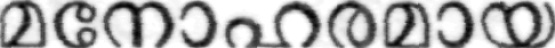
മനോഹരമായ
